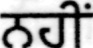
ਨਹੀਂ
